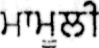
ਮਾਮੂਲੀ
